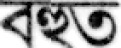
বহুত
